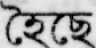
হৈছে
